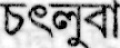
চৎলুবা
